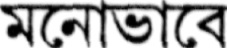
মনোভাবে
